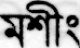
মশীং
